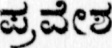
ಪ್ರವೇಶ
